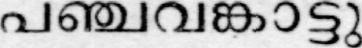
പഞ്ചവങ്കാട്ടു
